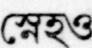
স্নেহও
